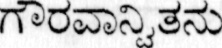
ಗೌರವಾನ್ವಿತನು
